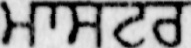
ਮਾਸਟਰ
